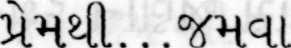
પ્રેમથી...જમવા
